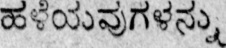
ಹಳೆಯವುಗಳನ್ನು
